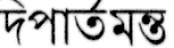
দিপার্তমন্ত
